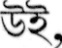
উই,
